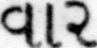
વાર
